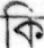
কি
